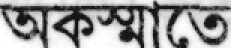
অকস্মাতে
